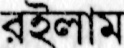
রইলাম
